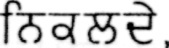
ਨਿਕਲਦੇ,
